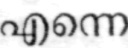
എന്നെ
